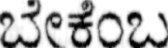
ಬೇಕೆಂಬ
